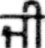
ਜੀ
